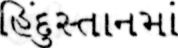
હિંદુસ્તાનમાં
